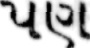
પણ
